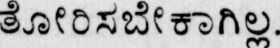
ತೋರಿಸಬೇಕಾಗಿಲ್ಲ.
